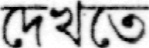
দেখতে
